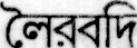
লৈরবদি
